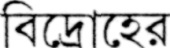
বিদ্রোহের
